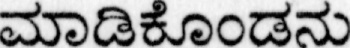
ಮಾಡಿಕೊಂಡನು
